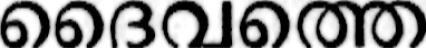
ദൈവത്തെ
